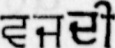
ਵਜਦੀ
